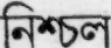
নিশ্চল
